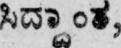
ಸಿದ್ದಾಂತ,
